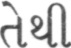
તેથી
